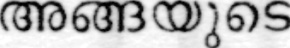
അങ്ങയുടെ
